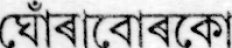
ঘোঁৰাবোৰকো
